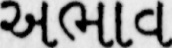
અભાવ
